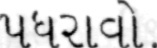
પધરાવો.
